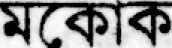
মকোক
